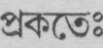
প্ৰকতেঃ
